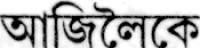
আজিলৈকে
